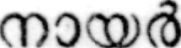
നായര്‍
